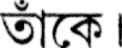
তাঁকে।
